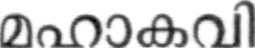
മഹാകവി
